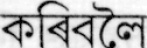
কৰিবলৈ
